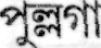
পুল্লগা
